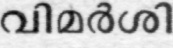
വിമര്‍ശി
